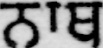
ਨਾਥ
